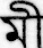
মী
